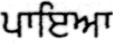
ਪਾਇਆ
